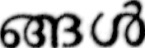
ങ്ങള്‍
